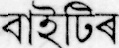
বাইটিৰ
